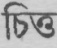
চিত্ত
